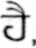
ਹੈ,
